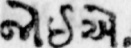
જોઈએ.
